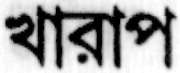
খারাপ
